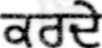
ਕਰਦੇ
